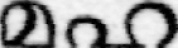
മഹ
